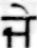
ਜੇ
